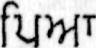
ਪਿਆ
